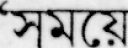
'সময়ে
